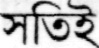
সতিই
